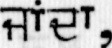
ਜਾਂਦਾ,
